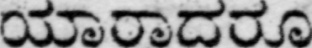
ಯಾರಾದರೂ
